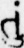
તું
